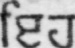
ਇਹ
